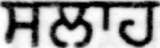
ਸਲਾਹ
